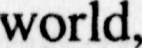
world,
